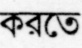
করতে
